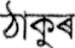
ঠাকুৰ
